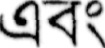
এবং
